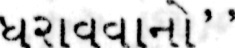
ધરાવવાનો"
